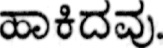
ಹಾಕಿದವು.
